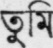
তুমি
